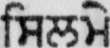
ਸਿਲਮੇ
